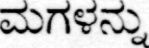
ಮಗಳನ್ನು
